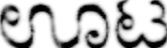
ಊಟ
